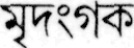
মৃদংগক
